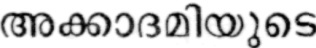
അക്കാദമിയുടെ
